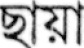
ছায়া
